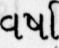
વર્ષા
